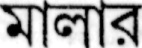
মালার
